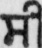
ਸੀ
